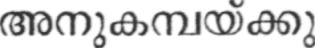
അനുകമ്പയ്ക്കു
